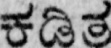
ಕಡಿತ
